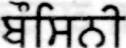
ਬੌਸਿਨੀ
